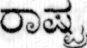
ರಾಷ್ಟ್ರ
